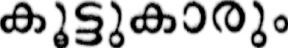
കൂട്ടുകാരും
